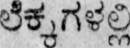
ಲೆಕ್ಕಗಳಲ್ಲಿ
